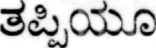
ತಪ್ಪಿಯೂ
